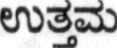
ಉತ್ತಮ
